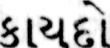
કાયદો
